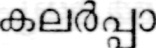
കലര്‍പ്പാ
